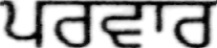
ਪਰਵਾਰ
